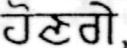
ਹੋਣਗੇ,
